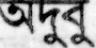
অদুবু
